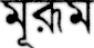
মূরূম
